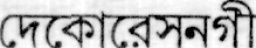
দেকোরেসনগী
